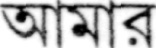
আমার
